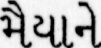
મૈયાને
